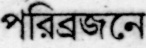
পরিব্রজনে
